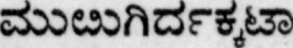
ಮುೞುಗಿರ್ದಕ್ಕಟಾ
